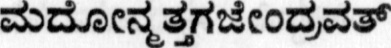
ಮದೋನ್ಮತ್ತಗಜೇಂದ್ರವತ್
